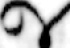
જ.
